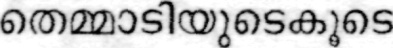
തെമ്മാടിയുടെകൂടെ
